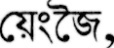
য়েংজৈ,
